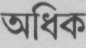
অধিক
